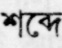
শব্দে
